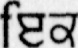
ਇਕ
